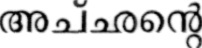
അച്ഛന്റെ
